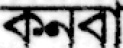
কনবা
